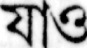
যাও
